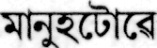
মানুহটোৱে
